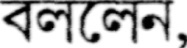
বললেন,
